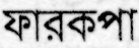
ফারকপা
